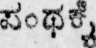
ಪಂಥಕ್ಕೆ
